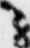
કે
